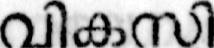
വികസി
